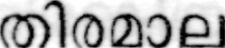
തിരമാല
